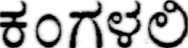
ಕಂಗಳಲಿ
